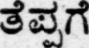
ತೆಪ್ಪಗೆ
